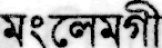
মংলেমগী
